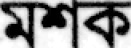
মশক
